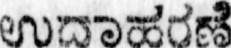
ಉದಾಹರಣೆ
